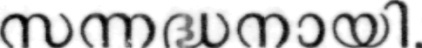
സന്നദ്ധനായി.
